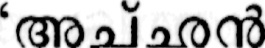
‘അച്ഛന്‍
